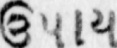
ઉપાય
